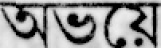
অভয়ে
